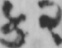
કર
